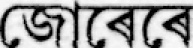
জোৰেৰে
